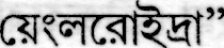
য়েংলরোইদ্রা”
